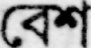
বেশ
